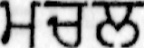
ਮਚਲ
